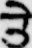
ਤੇ
